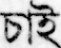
চাই
